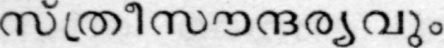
സ്ത്രീസൌന്ദര്യവും
